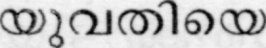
യുവതിയെ
